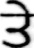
ਤੇ
